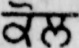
ਕੋਲ
